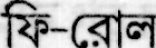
ফি-রোল
